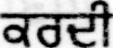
ਕਰਦੀ
